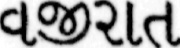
વજીરાત
